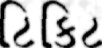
ટિકિટ
